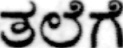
ತಲೆಗೆ
